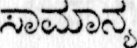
ಸಾಮಾನ್ಯ
